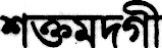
শক্তমদগী
